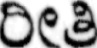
ರೀತಿ
